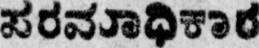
ಪರಮಾಧಿಕಾರ
